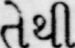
તેથી
